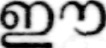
ഈ
